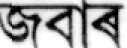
জবাৰ
